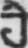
ਹੈ
